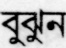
বুঝুন
